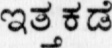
ಇತ್ತಕಡೆ
